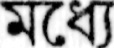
মধ্যে
